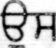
ਉਸ
